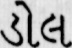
ડોલ
